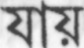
যায়
